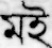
মই
